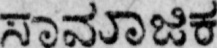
ಸಾಮಾಜಿಕ
